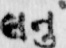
લનું
